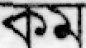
কম
